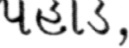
પહાડ,
